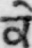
ਕੇ
